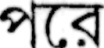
পরে
